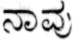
ನಾವು
